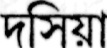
দসিয়া
